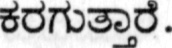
ಕರಗುತ್ತಾರೆ.
